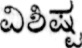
ವಿಶಿಷ್ಟ
